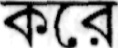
করে
